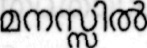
മനസ്സില്‍
